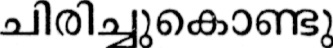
ചിരിച്ചുകൊണ്ടു
